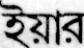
ইয়ার
